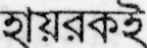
হায়রকই
